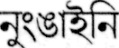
নুংঙাইনি
